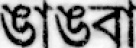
ঙাঙবা
